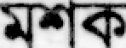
মশক
